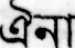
ঐনা
